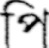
পি
